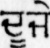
ਦੂਜੇ
